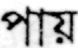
পায়
